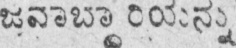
ಜವಾಬ್ದಾರಿಯನ್ನು
